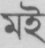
মই
